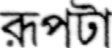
রূপটা
